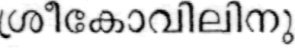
ശ്രീകോവിലിനു
